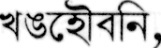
খঙহৌবনি,
